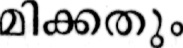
മിക്കതും
